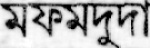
মফমদুদা
